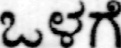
ಒಳಗೆ
